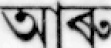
আৰু
